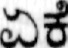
ಏಕೆ
